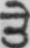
ਤੇ
